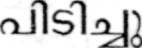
പിടിച്ചു
